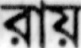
রায়
